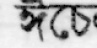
থবক্তু
